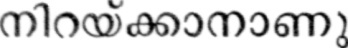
നിറയ്ക്കാനാണു
